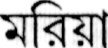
মরিয়া
